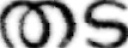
തട
